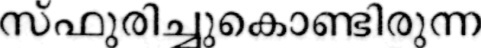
സ്ഫുരിച്ചുകൊണ്ടിരുന്ന
